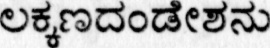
ಲಕ್ಕಣದಂಡೇಶನು
